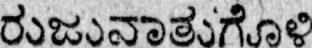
ರುಜುವಾತುಗೊಳಿ
